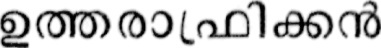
ഉത്തരാഫ്രിക്കന്‍
